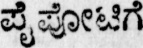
ಪೈಪೋಟಿಗೆ
